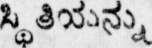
ಸ್ಥಿತಿಯನ್ನು
